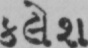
કલેશ
